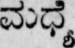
ಮಧ್ಯೆ
